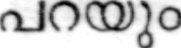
പറയും
